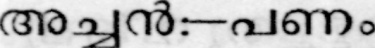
അച്ചന്‍:-പണം
